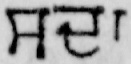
ਸਦਾ
